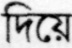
দিয়ে
